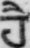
ਹੈ
